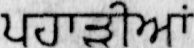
ਪਹਾੜੀਆਂ
